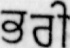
ਭਰੀ
